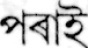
পৰাই
